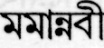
মমান্নবী
